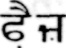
ਫ਼ੈਜ਼
